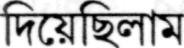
দিয়েছিলাম
